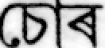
চোৰ
